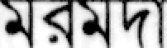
মরমদা
